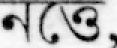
নত্তে,
